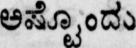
ಅಷ್ಟೊಂದು
